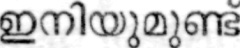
ഇനിയുമുണ്ട്
